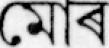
মোৰ
